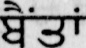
ਬੈਂਤਾਂ
